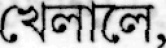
খেলালে,
